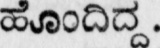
ಹೊಂದಿದ್ದ.
